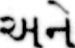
અને
